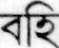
বহি
